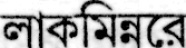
লাকমিন্নরে
